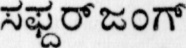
ಸಫ್ದರ್‌ಜಂಗ್
